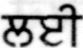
ਲਈ
